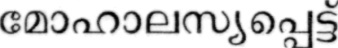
മോഹാലസ്യപ്പെട്ട്
